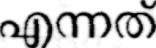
എന്നത്
